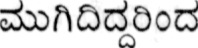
ಮುಗಿದಿದ್ದರಿಂದ
